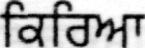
ਕਿਰਿਆ
